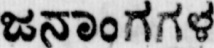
ಜನಾಂಗಗಳ
